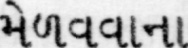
મેળવવાના
